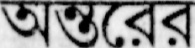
অন্তরের
